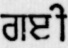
ਗਈ
